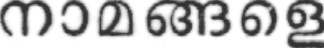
നാമങ്ങളെ
